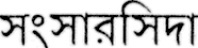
সংসারসিদা
